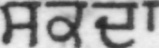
ਸਕਦਾ
